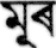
মূৰ
